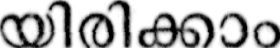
യിരിക്കാം
